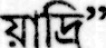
য়াদ্রি”
